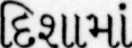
દિશામાં
